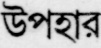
উপহার
